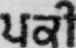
ਪਕੀ
